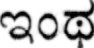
ಇಂಥ
